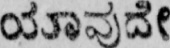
ಯಾವುದೇ
